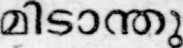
മിടാന്തു
